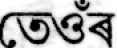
তেওঁৰ
